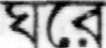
ঘরে
